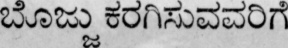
ಬೊಜ್ಜುಕರಗಿಸುವವರಿಗೆ
